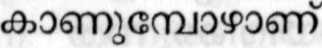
കാണുമ്പോഴാണ്
